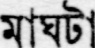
মাঘটা
